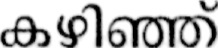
കഴിഞ്ഞ്
